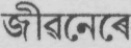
জীৱনেৰে
